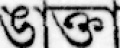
ঙাক্তা
